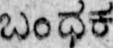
ಬಂಧಕ
